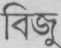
বিজু
